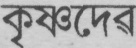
কৃষ্ণদেৱ
